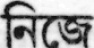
নিজে
